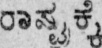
ರಾಷ್ಟ್ರಕ್ಕೆ
